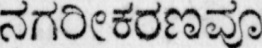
ನಗರೀಕರಣವೂ
